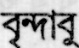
বৃন্দাবু
